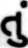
તું
